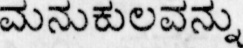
ಮನುಕುಲವನ್ನು
